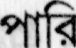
পারি
